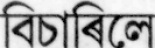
বিচাৰিলে
